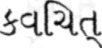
કવચિત્
